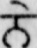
ਨੇ
